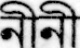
নীনী
